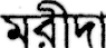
মরীদা
